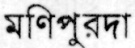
মণিপুরদা
